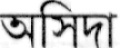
অসিদা
